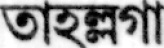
তাহল্লগা
